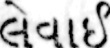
લેવાઈ
